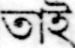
তাই
